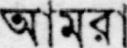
আমরা
